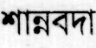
শান্নবদা
